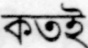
কতই
